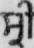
ਸ੍ਰੀ
